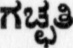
ಗಚ್ಛತಿ
